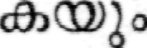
കയും
